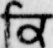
ਕਿ
